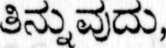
ತಿನ್ನುವುದು,
